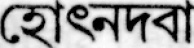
হোৎনদবা
